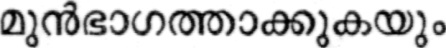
മുന്‍ഭാഗത്താക്കുകയും
